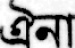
ঐনা
